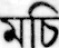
মচি
